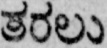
ತರಲು
